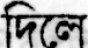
দিলে
